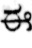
ಈ
